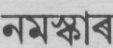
নমস্কাৰ
